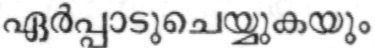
ഏര്‍പ്പാടുചെയ്യുകയും
